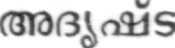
അദൃഷ്ട
